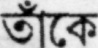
তাঁকে
